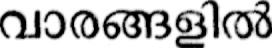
വാരങ്ങളില്‍
